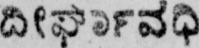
ದೀರ್ಘಾವಧಿ
